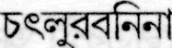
চৎলুরবনিনা
